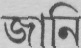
জানি
